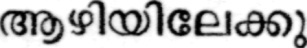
ആഴിയിലേക്കു
